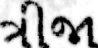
ત્રીજા
